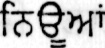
ਨਿਊਆਂ
